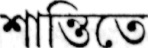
শান্তিতে
